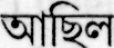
আছিল
